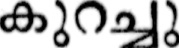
കുറച്ചു
